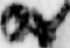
જ
